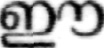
ഈ
